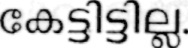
കേട്ടിട്ടില്ല.
